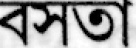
বসতা
